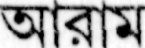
আরাম
